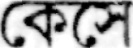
কেসে
